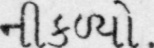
નીકળ્યો.
